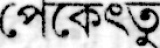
পেকেৎতু
